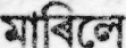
মাৰিলে
